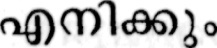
എനിക്കും
